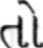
તો
